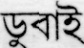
ডুবাই
